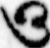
ও
